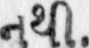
નથી.
